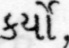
કર્યો,
